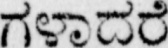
ಗಳಾದರೆ
